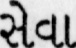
સેવા
